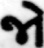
જો
